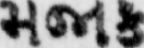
મજાક
